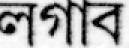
লগাব
